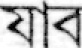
যাব
